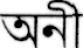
অনী
